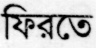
ফিরতে
